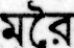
মরৈ
